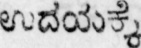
ಉದಯಕ್ಕೆ
